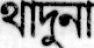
থাদুনা
